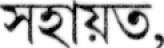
সহায়ত,
